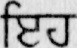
ਇਹ
